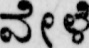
ವೇಳೆ
